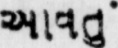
આવતું
